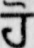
ਹੋ
